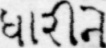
ધારીને
